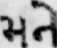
મને
